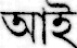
আই
